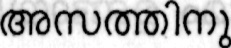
അസത്തിനു
